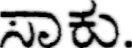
ಸಾಕು.
